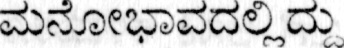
ಮನೋಭಾವದಲ್ಲಿದ್ದು
